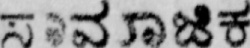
ಸಾಮಾಜಿಕ
